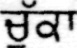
ਚੁੱਕਾ
